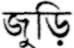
জুড়ি
